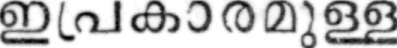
ഇപ്രകാരമുള്ള
